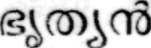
ഭൃത്യന്‍
